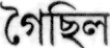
গৈছিল
